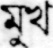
মুখ
